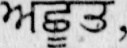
ਅਛੂਤ,
